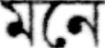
মনে
